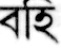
বহি
